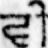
ਵੀ
